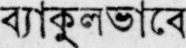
ব্যাকুলভাবে
